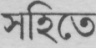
সহিতে
